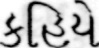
કહિયે
